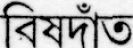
বিষদাঁত
